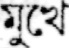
মুখে
